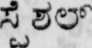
ಸ್ಪೆಶಲ್
